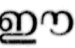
ഈ
